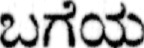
ಬಗೆಯ
